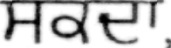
ਸਕਦਾ,
